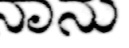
ನಾನು
